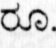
ರೂ.
